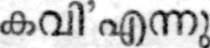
കവി'എന്നു
